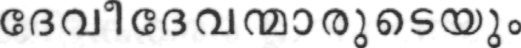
ദേവീദേവന്മാരുടെയും
